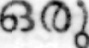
ഒരു
